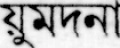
য়ুমদনা
